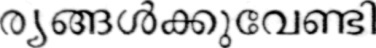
ര്യങ്ങള്‍ക്കുവേണ്ടി
